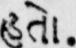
હતો.
